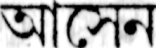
আসেন
